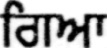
ਗਿਆ
